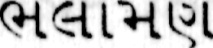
ભલામણ
